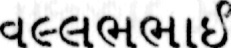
વલ્લભભાઈ
